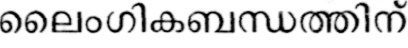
ലൈംഗികബന്ധത്തിന്
